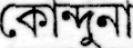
কোন্দুনা
